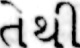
તેથી
